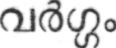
വര്‍ഗ്ഗം
